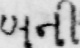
બની
